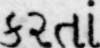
કરતાં
